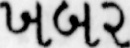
ખબર
